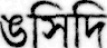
ঙসিদি
